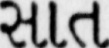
સાત
